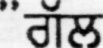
''ਗੱਲ
